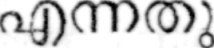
എന്നതു
